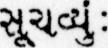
સૂચવ્યું:
